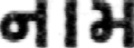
નામ
